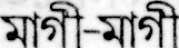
মাগী-মাগী
